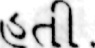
હતી.
